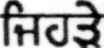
ਜਿਹੜੇ
